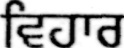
ਵਿਹਾਰ
